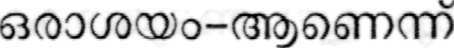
ഒരാശയം-ആണെന്ന്
